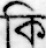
কি
